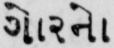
ગોરનો
